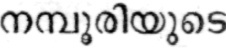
നമ്പൂരിയുടെ
